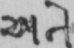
અને
